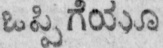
ಒಪ್ಪಿಗೆಯೂ
